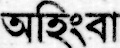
অহিংবা
